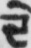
ਦੇ
